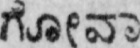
ಗೋವಾ
